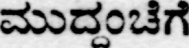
ಮುದ್ದಂಚೆಗೆ
